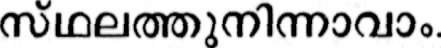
സ്ഥലത്തുനിന്നാവാം.
